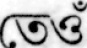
তেওঁ
